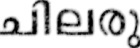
ചിലരു
